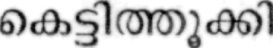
കെട്ടിത്തൂക്കി
